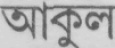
আকুল
